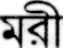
মরী
